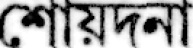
শোয়দনা
